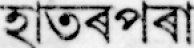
হাতৰপৰা
